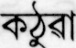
কঠুৱা
